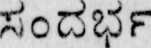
ಸಂದರ್ಭ
